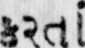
કરતાં
